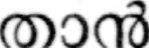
താന്‍
